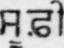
ਸੂਫ਼ੀ
